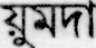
য়ুমদা
